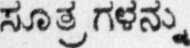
ಸೂತ್ರಗಳನ್ನು
